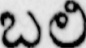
ಬಲಿ
